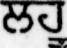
ਲਹੂ
